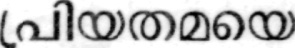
പ്രിയതമയെ
